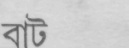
বাট
